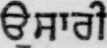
ਉਸਾਰੀ
